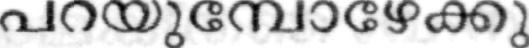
പറയുമ്പോഴേക്കു
